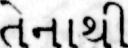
તેનાથી
